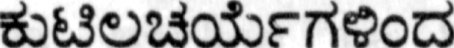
ಕುಟಿಲಚರ್ಯೆಗಳಿ೦ದ
